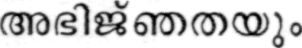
അഭിജ്ഞതയും
